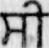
ਸੀ
